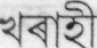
খৰাহী
